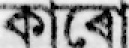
কাৰো
